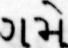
ગમે
